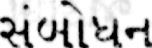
સંબોધન
